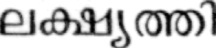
ലക്ഷ്യത്തി
